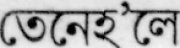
তেনেহ'লে
